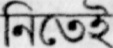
নিতেই
